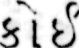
કોઈ
